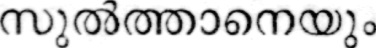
സുല്‍ത്താനെയും
